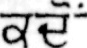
ਕਦੋਂ
